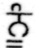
ਨੂੰ
